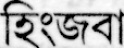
হিংজবা
